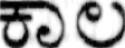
ಕಾಲ
